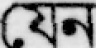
যেন
